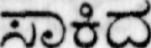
ಸಾಕಿದ
